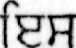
ਇਸ
